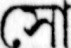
সো
